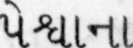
પેશ્વાના
